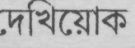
দেখিয়োক
